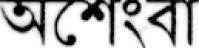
অশেংবা
